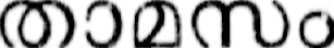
താമസം
